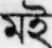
মই
